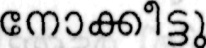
നോക്കീട്ടു
